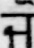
ਜੋ
